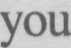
you
